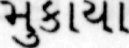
મુકાયા
